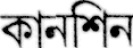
কানশিন
